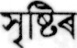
সৃষ্টিৰ
